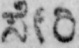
ಸೇರಿ
